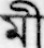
মী
